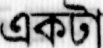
একটা
